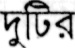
দুটির
